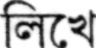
লিখে
